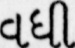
વધી
